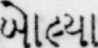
બોલ્યા
